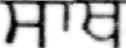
ਸਾਥ
